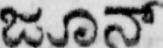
ಜೂನ್
